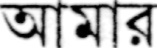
আমার
